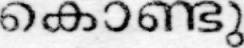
കൊണ്ടു
